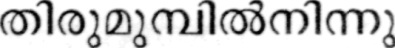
തിരുമുമ്പില്‍നിന്നു
